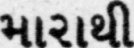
મારાથી
